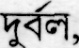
দুর্বল,
